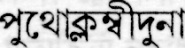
পুথোক্লম্বীদুনা
